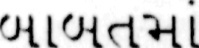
બાબતમાં
